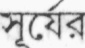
সূর্যের
